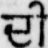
ਦੀ
